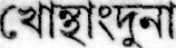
খোন্থাংদুনা
